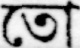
তো
